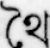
থৈ
